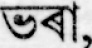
ভৰা,
